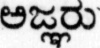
ಅಜ್ಞರು
